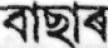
বাছাৰ
